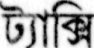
ট্যাক্সি
